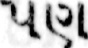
પણ
